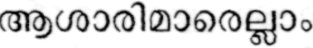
ആശാരിമാരെല്ലാം
